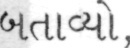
બતાવ્યો,
